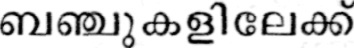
ബഞ്ചുകളിലേക്ക്
